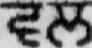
ਵਲ
